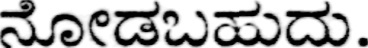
ನೋಡಬಹುದು.
